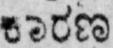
ಕಾರಣ
